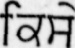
ਕਿਸੇ
